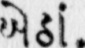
બેઠાં.
